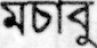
মচাবু
